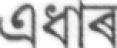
এধাৰ
